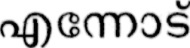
എന്നോട്
